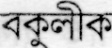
বকুলীক
